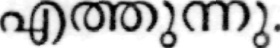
എത്തുന്നു.
